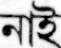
নাই
